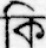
কি
